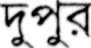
দুপুর
